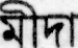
মীদা
